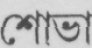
শোভা
